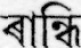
ৰান্ধি
